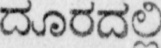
ದೂರದಲ್ಲಿ
